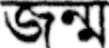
জন্ম
